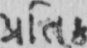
પ્રતિક
